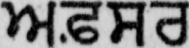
ਅਫ਼ਸਰ
